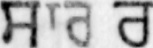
ਸਾਰਰ
